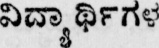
ವಿದ್ಯಾರ್ಥಿಗಳ
